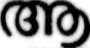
ആ
